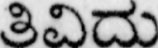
ತಿವಿದು
